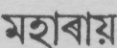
মহাৰায়
